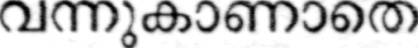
വന്നുകാണാതെ
